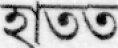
হাতত
